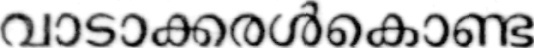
വാടാക്കരള്‍കൊണ്ട
